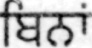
ਬਿਨਾਂ
